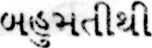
બહુમતીથી
